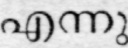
എന്നു
